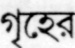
গৃহের
